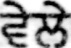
ਵੇਲੇ
